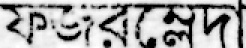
ফজরম্লেদা
